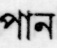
পান
